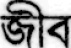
জীব
